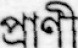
প্রাণী
